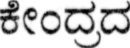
ಕೇಂದ್ರದ
